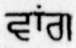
ਵਾਂਗ
